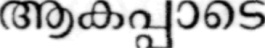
ആകപ്പാടെ
